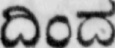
ದಿಂದ
